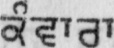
ਕੰਵਾਰਾ
